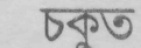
চকুত
